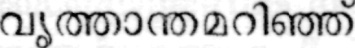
വൃത്താന്തമറിഞ്ഞ്
